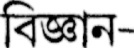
বিজ্ঞান-
